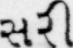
સરી
